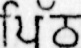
ਪਿੱਠ
